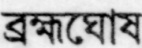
ব্রহ্মঘোষ
